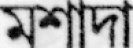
মশাদা
